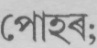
পোহৰ;
